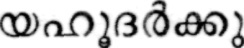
യഹൂദര്‍ക്കു
